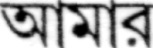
আমার
